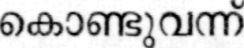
കൊണ്ടുവന്ന്
